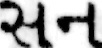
સન
